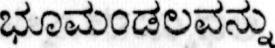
ಭೂಮಂಡಲವನ್ನು
